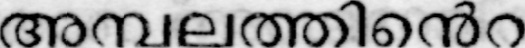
അമ്പലത്തിന്റെ
